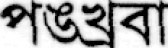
পঙখ্রবা
